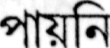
পায়নি
